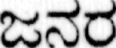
ಜನರ
